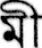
মী
